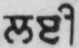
ਲਈ
